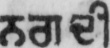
ਨਗਦੀ
